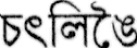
চৎলিঙৈ
